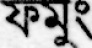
ফমুং
